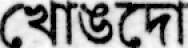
খোঙদো
